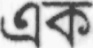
এক
